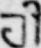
ਹੀ
